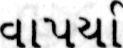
વાપર્યા
